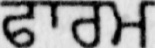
ਫਾਰਮ
